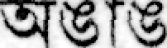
অঙাঙ
